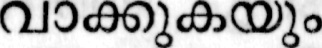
വാക്കുകയും
